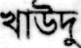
খাউদু
